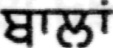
ਬਾਲਾਂ
